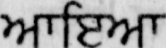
ਆਇਆ
